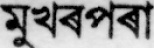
মুখৰপৰা
